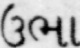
ઉભા
